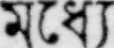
মধ্যে
